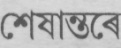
শেষান্তৰে
